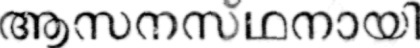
ആസനസ്ഥനായി
